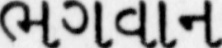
ભગવાન
